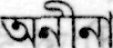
অনীনা
